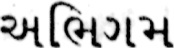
અભિગમ
